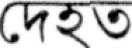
দেহত
